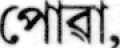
পোৱা,
